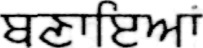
ਬਣਾਇਆਂ
